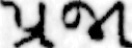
પ્રજા
